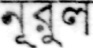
নূরুল
